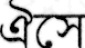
ঐসে
